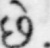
છે.
